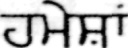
ਹਮੇਸ਼ਾਂ
